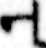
ન
